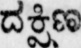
ದಕ್ಷಿಣ
